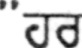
''ਹਰ
